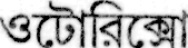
ওটোরিক্সো
